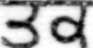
ਤਕ
